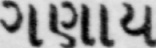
ગણાય
